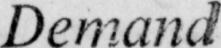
Demand
